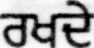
ਰਖਦੇ
